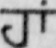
ਹਾਂ
